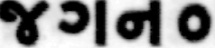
જગન.
